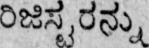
ರಿಜಿಸ್ಟರನ್ನು
